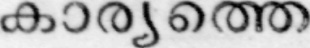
കാര്യത്തെ
